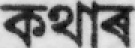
কথাৰ
